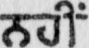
ਨਹੀਂ
